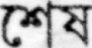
শেষ
